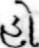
હો
